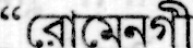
“রোমেনগী
